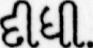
દીધી.
